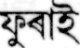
ফুৰাই
